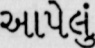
આપેલું
